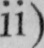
ii)
